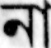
না
